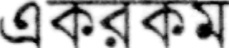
একরকম
